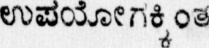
ಉಪಯೋಗಕ್ಕಿಂತ
